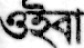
ওইবা
